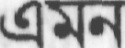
এমন
